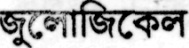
জুলোজিকেল
